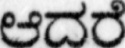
ಆದರೆ
